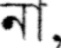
না,
